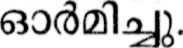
ഓര്‍മിച്ചു.
